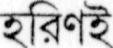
হরিণই
